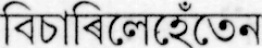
বিচাৰিলেহেঁতেন
